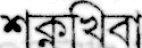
শক্নখিবা
